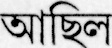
আছিল
